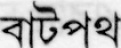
বাটপথ
